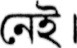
নেই।
